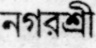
নগরশ্রী
